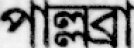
পাল্লব্রা
